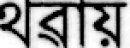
থৱায়
